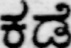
ಕಡೆ
